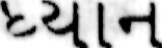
ધ્યાન
